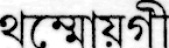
থম্মোয়গী
